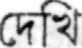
দেখি
